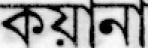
কয়ানা
